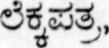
ಲೆಕ್ಕಪತ್ರ,
